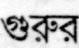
গুরুর
